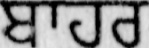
ਬਾਹਰ
